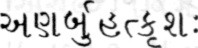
અણર્બુહત્કૃશઃ
